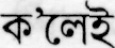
ক'লেই
